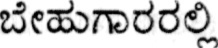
ಬೇಹುಗಾರರಲ್ಲಿ
